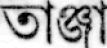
তাঞ্জা
